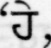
'ਹੇ,
